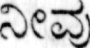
ನೀವು
